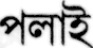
পলাই
